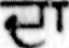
ਦਾ
